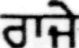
ਰਾਜੇ
